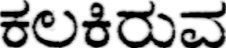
ಕಲಕಿರುವ
